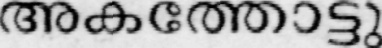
അകത്തോട്ടു
